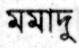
মমাদু
